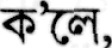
ক'লে,
